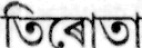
তিৰোতা
